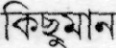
কিছুমান
